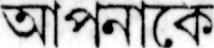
আপনাকে
